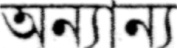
অন্যান্য
